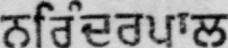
ਨਰਿੰਦਰਪਾਲ
